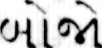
બોજો
